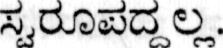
ಸ್ವರೂಪದ್ದಲ್ಲ.
